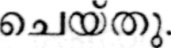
ചെയ്തു.
